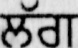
ਲੱਗ
